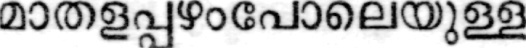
മാതളപ്പഴംപോലെയുള്ള
